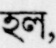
হল,
